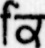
ਕਿ
